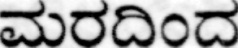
ಮರದಿಂದ
